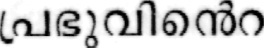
പ്രഭുവിന്റെ
